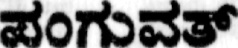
ಪಂಗುವತ್
